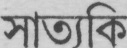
সাত্যকি
